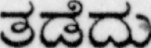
ತಡೆದು
